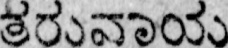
ತರುವಾಯ
